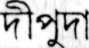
দীপুদা
